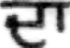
ਦਾ
